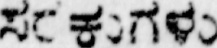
ಸರಕುಗಳು
